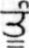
ਤੂੰ
